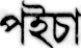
পইচা
